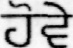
ਹੋਵੇ
